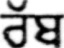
ਰੱਬ
